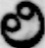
ಲಿ
